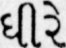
ધીરે
